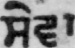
ਸੇਵਾ
